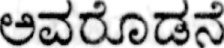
ಅವರೊಡನೆ
